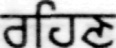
ਰਹਿਣ
